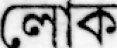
লোক
